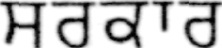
ਸਰਕਾਰ
